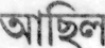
আছিল
